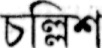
চল্লিশ
